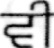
ਵੀ
